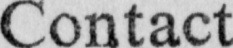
Contact
